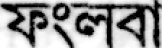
ফংলবা
